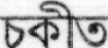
চকীত
